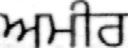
ਅਮੀਰ
